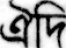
ঐদি
